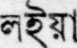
লইয়া
